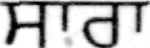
ਸਾਰਾ
